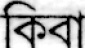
কিবা
